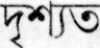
দৃশ্যত
